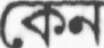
কেন
